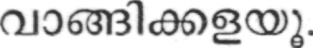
വാങ്ങിക്കളയൂ.
